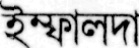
ইম্ফালদা
